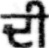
ਦੀ
